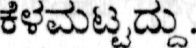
ಕೆಳಮಟ್ಟದ್ದು.
